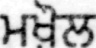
ਮਖ਼ੌਲ
